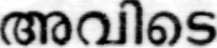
അവിടെ
